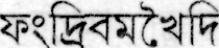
ফংদ্রিবমখৈ
